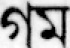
গম
